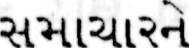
સમાચારને
